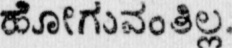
ಹೋಗುವಂತಿಲ್ಲ.
